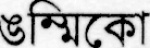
ঙম্মিকো
